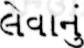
લેવાનું
